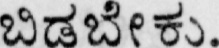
ಬಿಡಬೇಕು.
